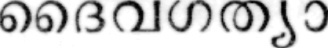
ദൈവഗത്യാ
